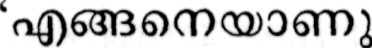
‘എങ്ങനെയാണു
